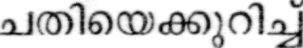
ചതിയെക്കുറിച്ച്
